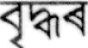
বৃদ্ধৰ
